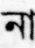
না
